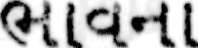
ભાવના
